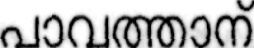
പാവത്താന്
